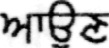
ਆਉਣ
